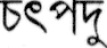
চৎপদু
